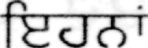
ਇਹਨਾਂ
